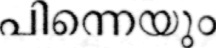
പിന്നെയും
